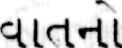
વાતનો
